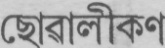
ছোৱালীকণ
